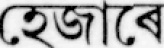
হেজাৰে
